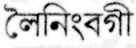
লৈনিংবগী
